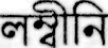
লম্বীনি
